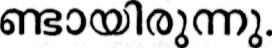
ണ്ടായിരുന്നു.
